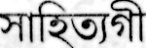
সাহিত্যগী
